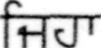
ਜਿਹਾ
